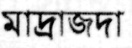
মাদ্রাজদা
